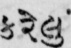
કરેલું
